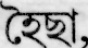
হৈছা,
